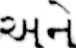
અને
